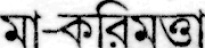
মা-করিমত্তা
